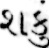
શકું
